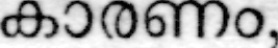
കാരണം,
